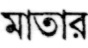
মাতার
